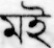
মই
